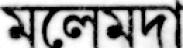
মলেমদা
